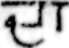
ਦਾ
